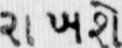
રાખશે
